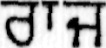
ਰਾਜ
